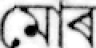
মোৰ
